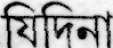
যিদিনা
